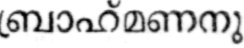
ബ്രാഹ്മണനു
